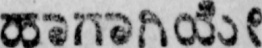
ಹಾಗಾಗಿಯೇ
